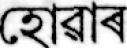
হোৱাৰ
